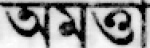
অমত্তা
